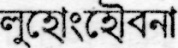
লুহোংহৌবনা
